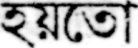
হয়তো
